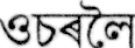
ওচৰলৈ
